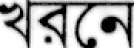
খরনে
